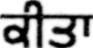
ਕੀਤਾ
